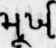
મૂર્ખ
